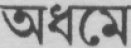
অধমে
